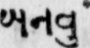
બનવું
